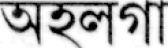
অহলগা
